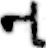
ન
